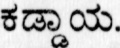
ಕಡ್ಡಾಯ.
